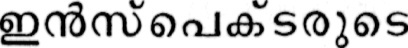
ഇന്‍സ്പെക്ടരുടെ
